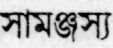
সামঞ্জস্য
